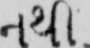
નથી.
